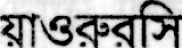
য়াওরুরসি
